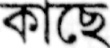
কাছে
